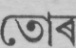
তোৰ
